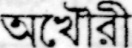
অখৌরী
